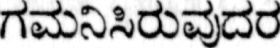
ಗಮನಿಸಿರುವುದರ
